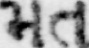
મત
